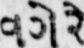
વગેરે
